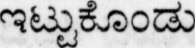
ಇಟ್ಟುಕೊಂಡು
